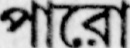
পারো
